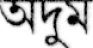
অদুম
